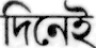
দিনেই
